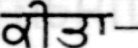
ਕੀਤਾ-
